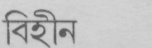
বিহীন
